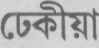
ঢেকীয়া
